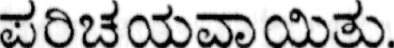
ಪರಿಚಯವಾಯಿತು.
